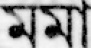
মমা
